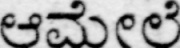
ಆಮೇಲೆ
